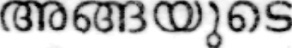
അങ്ങയുടെ
